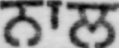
ਨਾਲ
